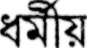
ধর্মীয়
